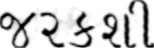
જરકશી
